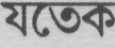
যতেক
